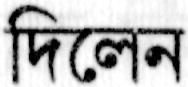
দিলেন
